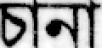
চানা
